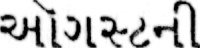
ઑગસ્ટની
